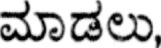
ಮಾಡಲು,
